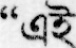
"এই
